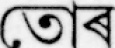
তোৰ
